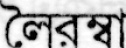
লৈরম্বা
